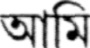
আমি
